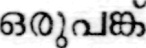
ഒരുപങ്ക്
